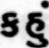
કહું
